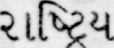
રાષ્ટ્રિય
